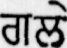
ਗਲੇ
